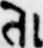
તો
